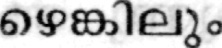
ഴെങ്കിലും
